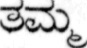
ತಮ್ಮ
